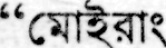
“মোইরাং
